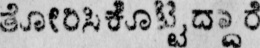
ತೋರಿಸಿಕೊಟ್ಟಿದ್ದಾರೆ
